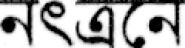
নৎত্রনে
